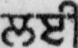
ਲਈ
